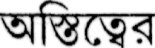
অস্তিত্বের
